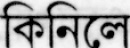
কিনিলে
